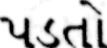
પડતો
